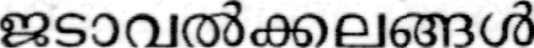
ജടാവല്‍ക്കലങ്ങള്‍
